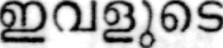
ഇവളുടെ
